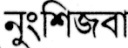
নুংশিজবা
